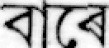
বাৰে
